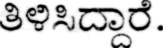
ತಿಳಿಸಿದ್ದಾರೆ.
